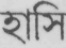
হাসি
